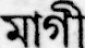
মাগী
